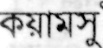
কয়ামসু
